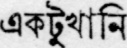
একটুখানি
